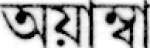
অয়াম্বা
